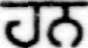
ਹਨ
